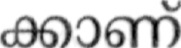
ക്കാണ്
